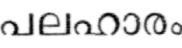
പലഹാരം
